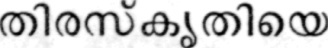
തിരസ്കൃതിയെ
